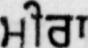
ਮੀਰਾ
